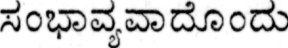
ಸಂಭಾವ್ಯವಾದೊಂದು
